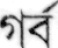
গর্ব
